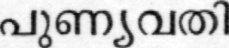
പുണ്യവതി
